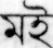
মই
